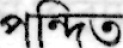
পন্দিত
